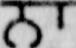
ਨਾ
